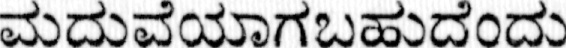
ಮದುವೆಯಾಗಬಹುದೆಂದು
